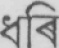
ধৰি
